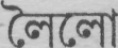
লৈলো
